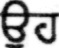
ਉਹ
